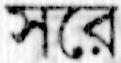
সরে
